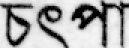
চৎপা
